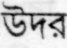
উদর
